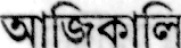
আজিকালি
